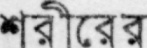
শরীরের
